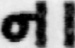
ના
